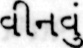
વીનવું
